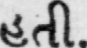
હતી.
